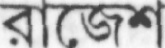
রাজেশ
